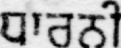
ਧਾਰਨੀ
